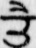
ਤੈ
